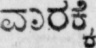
ವಾರಕ್ಕೆ
